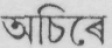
অচিৰে
